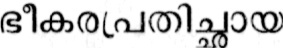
ഭീകരപ്രതിച്ഛായ
